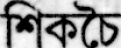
শিকচৈ
